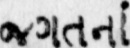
જગતનાં
